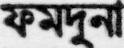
ফমদুনা
